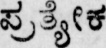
ಪ್ರತ್ಯೇಕ
